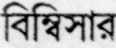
বিম্বিসার
